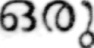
ഒരു
